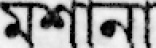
মশানা
